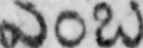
ಎಂಬ
